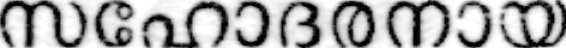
സഹോദരനായ
